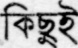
কিছুই
